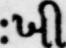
:ખી
